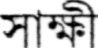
সাক্ষী
